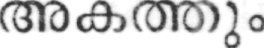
അകത്തും
